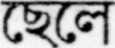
ছেলে
